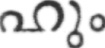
ഹും
